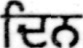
ਦਿਨ
